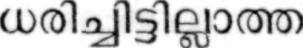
ധരിച്ചിട്ടില്ലാത്ത
